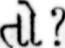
તો?
